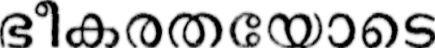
ഭീകരതയോടെ
